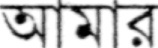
আমার
